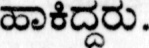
ಹಾಕಿದ್ದರು.
